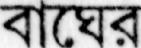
বাঘের
